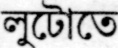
লুটোতে
